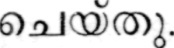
ചെയ്തു.
